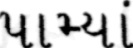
પામ્યાં
